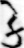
કે
